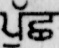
ਪੁੱਛ
